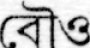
বৌও
